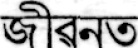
জীৱনত
